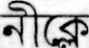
নীক্লে
